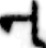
ન
